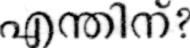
എന്തിന്?
